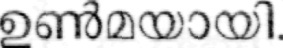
ഉണ്‍മയായി.
